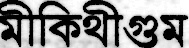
মীকিথীগুম
